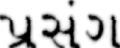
પ્રસંગ
